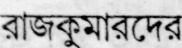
রাজকুমারদের
